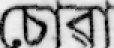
চোৱা
